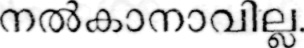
നല്‍കാനാവില്ല.
